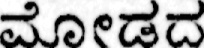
ಮೋಡದ
